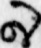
જે
